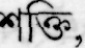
শক্তি,
